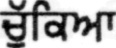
ਚੁੱਕਿਆ
